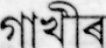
গাখীৰ
